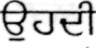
ਉਹਦੀ
